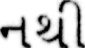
નથી
